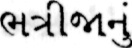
ભત્રીજાનું
